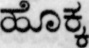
ಹೊಕ್ಕ
